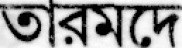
তারমদে
